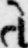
તે
